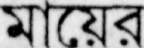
মায়ের
